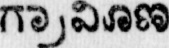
ಗ್ರಾಮೀಣ
